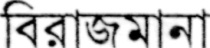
বিরাজমানা
